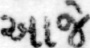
આજે
